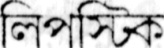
লিপস্টিক
